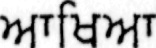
ਆਖਿਆ
